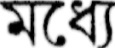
মধ্যে
